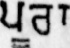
ਪੂਰਾ
